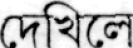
দেখিলে
